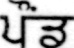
ਪੌਂਡ
